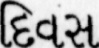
દિવસ
